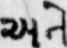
અને
